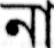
না
